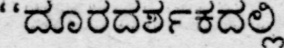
“ದೂರದರ್ಶಕದಲ್ಲಿ
